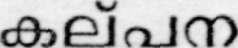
കല്പന
